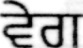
ਵੇਗ
